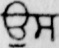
ਉਸ
